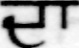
ਦਾ
